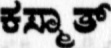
ಕಸ್ಮಾತ್
